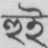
হুই
